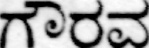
ಗೌರವ
